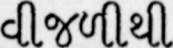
વીજળીથી
